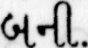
બની.
